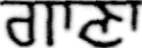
ਗਾਣਾ
